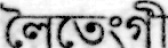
লৈতেংগী
